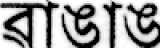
ৱাঙাঙ
